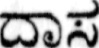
ದಾಸ
